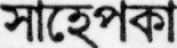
সাহেপকা
